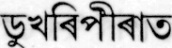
ডুখৰিপীৰাত
